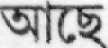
আছে
